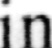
in
